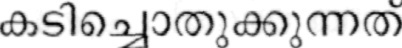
കടിച്ചൊതുക്കുന്നത്
